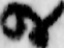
જ
